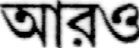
আরও
